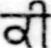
ਕੀ
